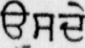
ਉਸਦੇ
